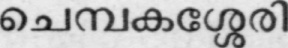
ചെമ്പകശ്ശേരി
